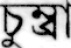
চু্ম্ব্রা
